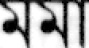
মমা
